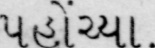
પહોંચ્યા.
